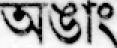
অঙাং
